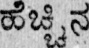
ಹೆಚ್ಚಿನ
